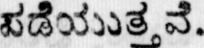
ಪಡೆಯುತ್ತವೆ.
